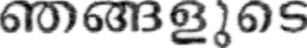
ഞങ്ങളുടെ
